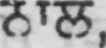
ਨਾਲ,
